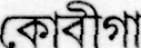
কোবীগা
